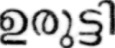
ഉരുട്ടി
